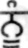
ਨੂੰ
